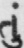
તું
